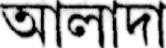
আলাদা
